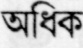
অধিক
